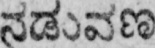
ನಡುವಣ
